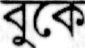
বুকে
